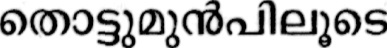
തൊട്ടുമുന്‍പിലൂടെ
